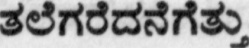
ತಲೆಗರೆದನೆಗೆತ್ತು
